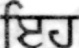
ਇਹ
